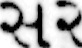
સર
